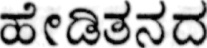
ಹೇಡಿತನದ
